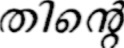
തിന്റെ
